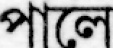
পালে
